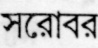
সরোবর
